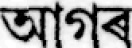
আগৰ
